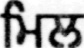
ਮਿਲ
